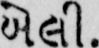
બેલી.
